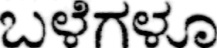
ಬಳೆಗಳೂ
